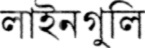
লাইনগুলি
